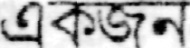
একজন
